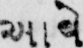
આવે
